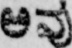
ಅವು
